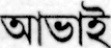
আভাই
